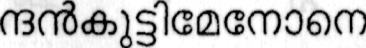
ന്ദന്‍കുട്ടിമേനോനെ
